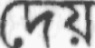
দেয়
